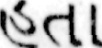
હતા
